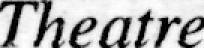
Theatre
